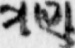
ત્રણ
